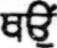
ਥਉਂ
